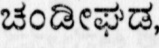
ಚಂಡೀಘಡ,
